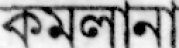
কমলানা
